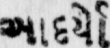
આદર્યો
